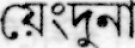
য়েংদুনা
